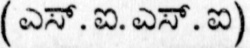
(ಎಸ್.ಐ.ಎಸ್.ಐ)
